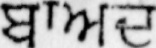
ਬਾਅਦ
